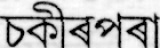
চকীৰপৰা
